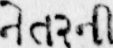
નેતરની
